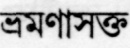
ভ্রমণাসক্ত
